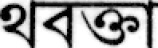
থবক্তা
